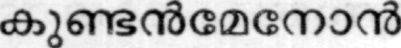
കുണ്ടന്‍മേനോന്‍
